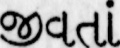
જીવતાં
